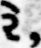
રે,
